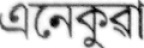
এনেকুৱা
